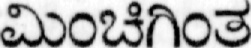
ಮಿಂಚಿಗಿಂತ
